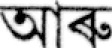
আৰু
